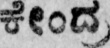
ಕೇಂದ್ರ
